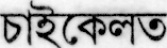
চাইকেলত
